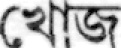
খোজ
